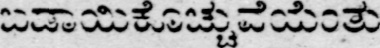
ಬಡಾಯಿಕೊಚ್ಚುವೆಯೆಂತು
